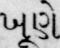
ખૂણે
